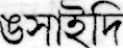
ঙসাইদি
